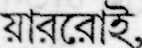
য়াররোই,
